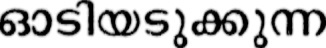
ഓടിയടുക്കുന്ന
